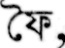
ফৈ,
